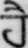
ਹੈ
